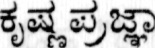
ಕೃಷ್ಣಪ್ರಜ್ಞಾ
